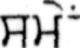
ਸਮੇਂ
